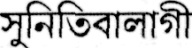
সুনিতিবালাগী
